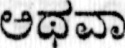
ಅಥವಾ
